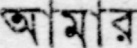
আমার
